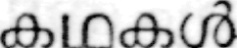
കഥകള്‍
